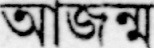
আজন্ম
